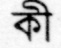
কী
